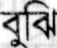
বুঝি
